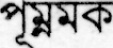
পূম্নমক
